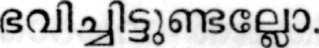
ഭവിച്ചിട്ടുണ്ടല്ലോ.
